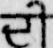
ਦੀ
